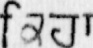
ਕਿਹਾ
